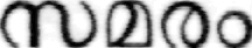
സമരം
